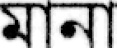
মানা
